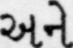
અને
